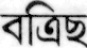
বত্রিছ
